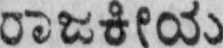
ರಾಜಕೀಯ
